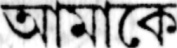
আমাকে
